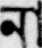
না
